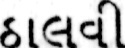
ઠાલવી
